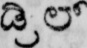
ಡ್ರಿಲ್
